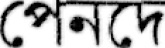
পেনদে
